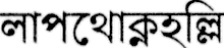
লাপথোক্নহল্লি
